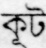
কূট
